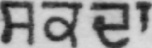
ਸਕਦਾ
